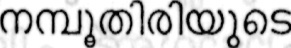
നമ്പൂതിരിയുടെ
